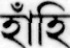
হাঁহি
